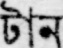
টান
